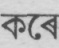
কৰে
